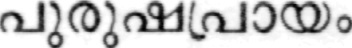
പുരുഷപ്രായം
